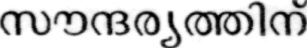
സൌന്ദര്യത്തിന്
